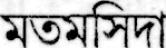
মতমসিদা
